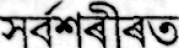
সর্বশৰীৰত
